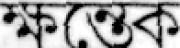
ক্ষন্তেক
